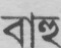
বাহু
